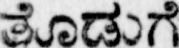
ತೊಡುಗೆ
